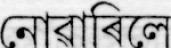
নোৱাৰিলে
